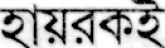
হায়রকই
